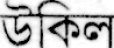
উকিল
